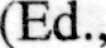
(Ed.
